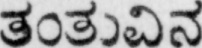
ತಂತುವಿನ
